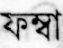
ফম্বা
